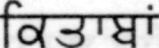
ਕਿਤਾਬਾਂ
